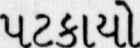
પટકાયો
